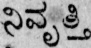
ನಿವೃತ್ತಿ
